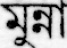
মুন্না
